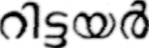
റിട്ടയര്‍
